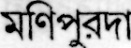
মণিপুরদা
